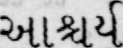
આશ્ચર્ય
